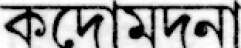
কদোমদনা
